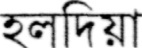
হলদিয়া
